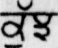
ਕੁੱਝ
